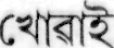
খোৱাই
